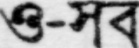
ও-সব
